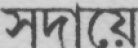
সদায়ে
